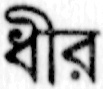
ধীর
